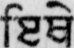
ਇਥੇ
